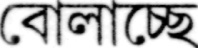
বোলাচ্ছে
